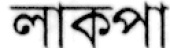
লাকপা
